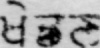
ਖੇਡਣ
